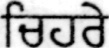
ਚਿਹਰੇ
